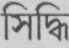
সিদ্ধি
